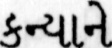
કન્યાને
